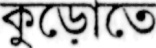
কুড়োতে
